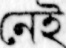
নেই
